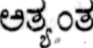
ಅತ್ಯಂತ
